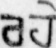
ਰਹੇ
